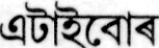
এটাইবোৰ
